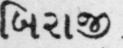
બિરાજી
